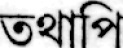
তথাপি
